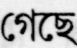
গেছে
